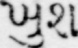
ખુશ
